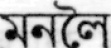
মনলৈ
